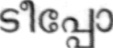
ടീപ്പോ
